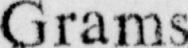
Grams
